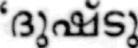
'ദുഷ്ടു
